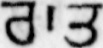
ਰਾਤ
